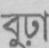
বুঢ়া
